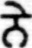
ਨੇ
